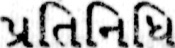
પ્રતિનિધિ
